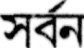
সর্বন
